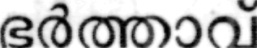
ഭര്‍ത്താവ്
